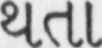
થતા
